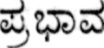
ಪ್ರಭಾವ
